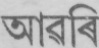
আৱৰি
